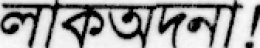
লাকঅদনা!
